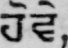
ਹੋਵੇ,
